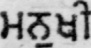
ਮਨੁਖੀ
